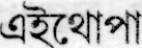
এইথোপা
